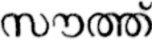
സൌത്ത്
